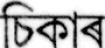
চিকাৰ
